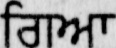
ਗਿਆ
